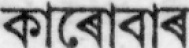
কাৰোবাৰ
